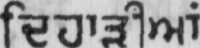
ਦਿਹਾੜੀਆਂ
